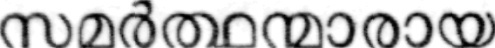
സമര്‍ത്ഥന്മാരായ
